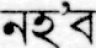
নহ'ব
